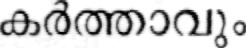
കര്‍ത്താവും
